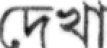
দেখা
